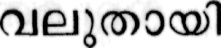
വലുതായി
